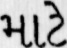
માટે
